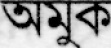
অমুক
